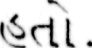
હતો.
